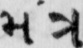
મંત્ર
